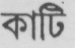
কাটি
